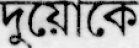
দুয়োকে
